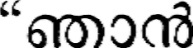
"ഞാന്‍
